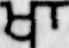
ਖਾ
